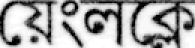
য়েংলক্লে
